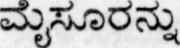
ಮೈಸೂರನ್ನು
